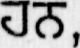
ਹਨ,
